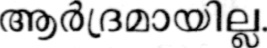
ആര്‍ദ്രമായില്ല.
